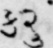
કરું
